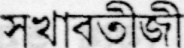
সখাবতীজী
